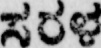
ಸರಳ
